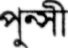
পুন্সী
